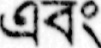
এবং
